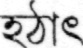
হঠাৎ
